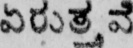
ಏರುತ್ತವೆ
